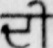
ਦੀ
